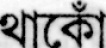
থাকোঁ
